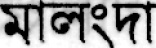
মালংদা
